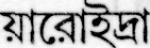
য়ারোইদ্রা
